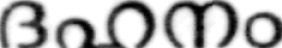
ദഹനം
